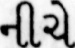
નીચે
